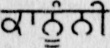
ਕਾਨੂੰਨੀ
